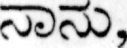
ನಾನು,
